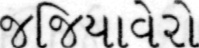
જજિયાવેરો
